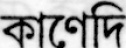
কাণেদি
